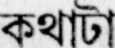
কথাটা
